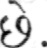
છે.
